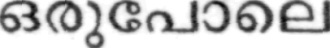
ഒരുപോലെ
